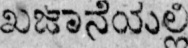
ಖಜಾನೆಯಲ್ಲಿ
